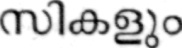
സികളും
